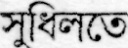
সুধিলতে
